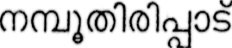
നമ്പൂതിരിപ്പാട്
